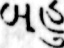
બહુ
